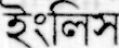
ইংলিস
